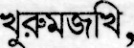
খুরুমজখি,
